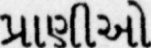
પ્રાણીઓ
